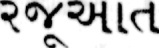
રજૂઆત
